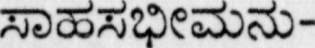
ಸಾಹಸಭೀಮನು-
